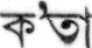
ক'তা
